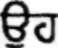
ਉਹ
